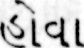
હોવા
